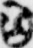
છે
